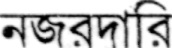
নজরদারি
